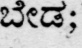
ಬೇಡ;
